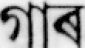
গাৰ
